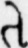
તે
